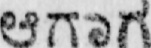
ಆಗಾಗ
